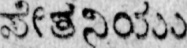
ವೇತನಿಯು
